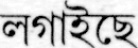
লগাইছে
